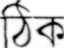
ঠিক
